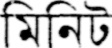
মিনিট
